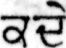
ਕਦੇ
